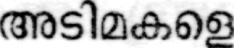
അടിമകളെ
